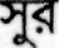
সুর
